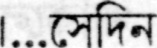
৷....সেদিন
